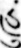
હું
